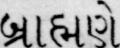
બ્રાહ્મણે
